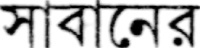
সাবানের
